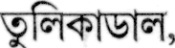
তুলিকাডাল,
